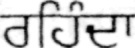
ਰਹਿੰਦਾ
